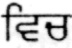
ਵਿਚ
